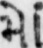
મોં
